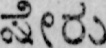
ಷೇರು
